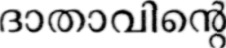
ദാതാവിന്റെ
